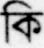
কি
